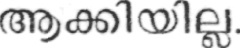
ആക്കിയില്ല.
